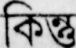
কিন্তু
